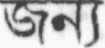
জন্য
